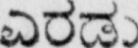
ಎರಡು
